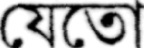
যেতো
